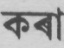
কৰা
